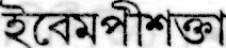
ইবেমপীশক্তা
